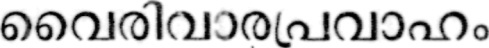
വൈരിവാരപ്രവാഹം
